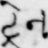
ટ્રેન
